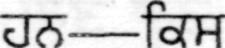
ਹਨ-ਕਿਸ
